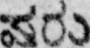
ಷರು
